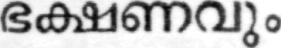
ഭക്ഷണവും
